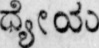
ಧ್ಯೇಯ
